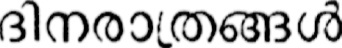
ദിനരാത്രങ്ങള്‍
